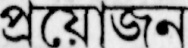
প্রয়োজন
